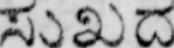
ಸುಖದ
